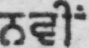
ਨਵੀਂ
